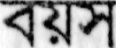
বয়স
